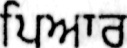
ਪਿਆਰ
